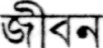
জীবন
